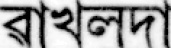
ৱাখলদা
